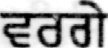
ਵਰਗੇ
